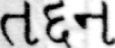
તદ્દન
